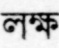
লক্ষ
